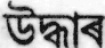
উদ্ধাৰ
